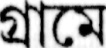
গ্রামে
